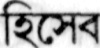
হিসেব
